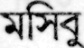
মসিবু
